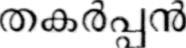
തകര്‍പ്പന്‍
